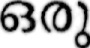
ഒരു
